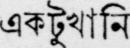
একটুখানি
